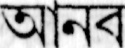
আনব
